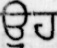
ਉਹ
